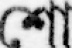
শো
